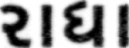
રાધા
